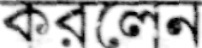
করলেন
